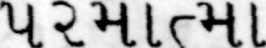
પરમાત્મા
